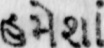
હમેશાં
